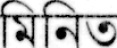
মিনিত
